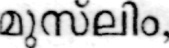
മുസ്ലിം,
